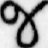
જ
